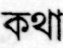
কথা
